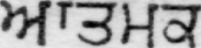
ਆਤਮਕ
